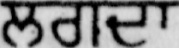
ਲਗਦਾ
